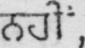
ਨਹੀਂ,
